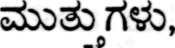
ಮುತ್ತುಗಳು,
